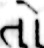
તો
